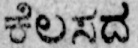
ಕೆಲಸದ
